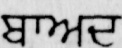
ਬਾਅਦ
